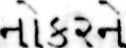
નોકરને
